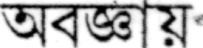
অবজ্ঞায়
